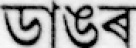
ডাঙৰ
